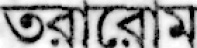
তারারোম
